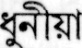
ধুনীয়া
